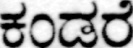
ಕಂಡರೆ
